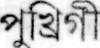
পুখ্রিগী
